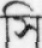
সি
